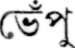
ভেঁপু
